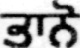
ਭਾਨੋ
